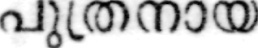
പുത്രനായ
